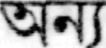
অন্য
